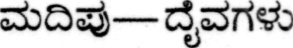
ಮದಿಪು-ದೈವಗಳು
